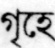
গৃহে
